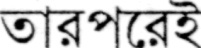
তারপরেই
